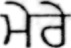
ਮੇਰੇ
